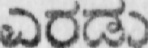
ಎರಡು
